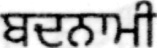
ਬਦਨਾਮੀ
